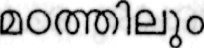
മഠത്തിലും
